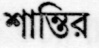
শান্তির
